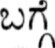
ಬಗ್ಗೆ
